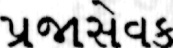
પ્રજાસેવક
